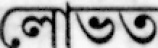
লোভত
